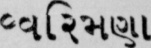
વ્વરિમણા
